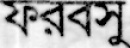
ফরবসু
